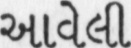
આવેલી
